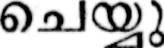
ചെയ്യു
